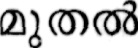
മുതല്‍
